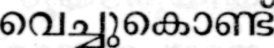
വെച്ചുകൊണ്ട്
